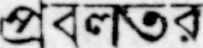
প্রবলতর
